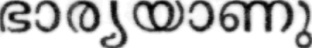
ഭാര്യയാണു
